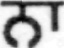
ਨਾ
